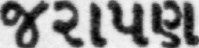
જરાપણ
